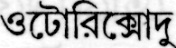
ওটোরিক্সোদু
